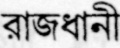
রাজধানী
